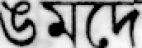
ঙমদে
